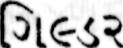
ગિલ્ડર
